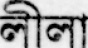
লীলা
